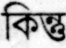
কিন্তু
